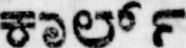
ಕಾರ್ಲ್
